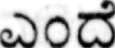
ಎಂದೆ
